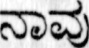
ನಾವು
